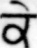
ਕੇ
